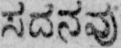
ಸದನವು
